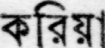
করিয়া
